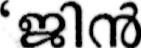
‘ജിന്‍
